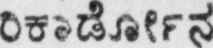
ರಿಕಾರ್ಡೋನ
